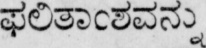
ಫಲಿತಾಂಶವನ್ನು
